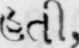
હતી,
